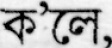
ক'লে,
